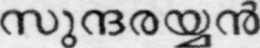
സുന്ദരയ്യന്‍
